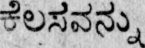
ಕೆಲಸವನ್ನು
